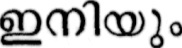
ഇനിയും
